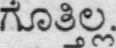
ಗೊತ್ತಿಲ್ಲ.
